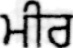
ਮੀਰ
